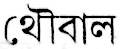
থৌবাল
